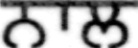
ਨਾਲ
